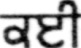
ਕਈ
